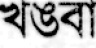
খঙবা
